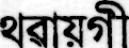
থৱায়গী
